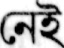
নেই
